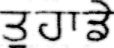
ਤੁਹਾਡੇ
